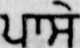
ਪਾਸੇ
